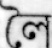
লৈ
